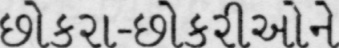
છોકરા-છોકરીઓને
